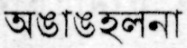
অঙাঙহলনা
